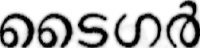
ടൈഗര്‍
